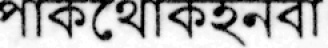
পাকথোকহনবা
